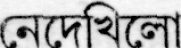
নেদেখিলো
